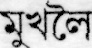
মুখলৈ
